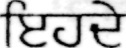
ਇਹਦੇ
